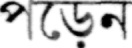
পড়েন
